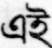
এই
